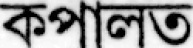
কপালত
